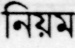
নিয়ম
